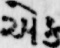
એક
